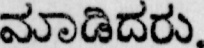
ಮಾಡಿದರು.
